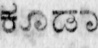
ಕೂಡಾ
